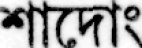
শাদোং
